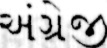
અંગ્રેજી
